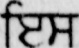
ਇਸ
